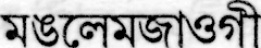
মঙলেমজাওগী
